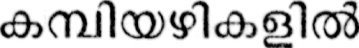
കമ്പിയഴികളില്‍
